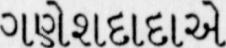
ગણેશદાદાએ
